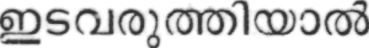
ഇടവരുത്തിയാല്‍
